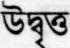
উদ্বৃত্ত
